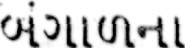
બંગાળના
